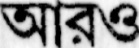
আরও
